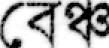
বেঞ্চ
